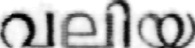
വലിയ
